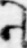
ને
